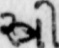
સ્ત્રી
